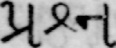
પ્રશ્ન
